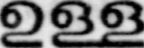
ഉള്ള
